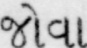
જોવા
